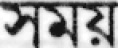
সময়
